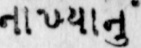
નાખ્યાનું
